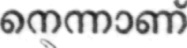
നെന്നാണ്
